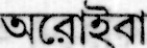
অরোইবা
